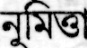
নুমিত্তা
